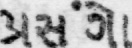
પ્રસંગો
